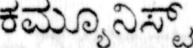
ಕಮ್ಯೂನಿಸ್ಟ್
